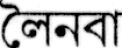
লৈনবা
